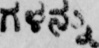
ಗಳನ್ನು
